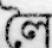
লৈ
